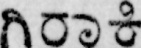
ಗಿರಾಕಿ
